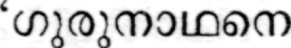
‘ഗുരുനാഥനെ
